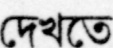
দেখতে
